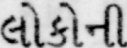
લોકોની
